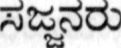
ಸಜ್ಜನರು
